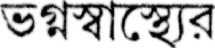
ভগ্নস্বাস্থ্যের
